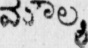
ಮೌಲ್ಯ
